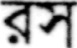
রস
